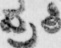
ಪ್ರತಿ
